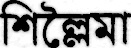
শিল্লৈমা
